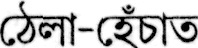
ঠেলা-হেঁচাত
